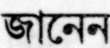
জানেন
